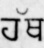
ਹੱਥ
